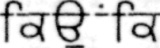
ਕਿਉਂਕਿ
